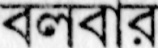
বলবার
